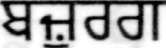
ਬਜ਼ੁਰਗ
